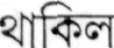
থাকিল
